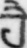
ਹੈ
